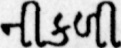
નીકળી
